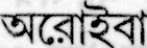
অরোইবা
